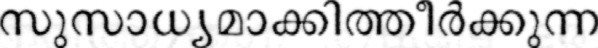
സുസാധ്യമാക്കിത്തീര്‍ക്കുന്ന
